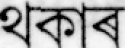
থকাৰ
